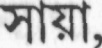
সায়া,
